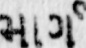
માર્ગ
